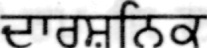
ਦਾਰਸ਼ਨਿਕ
